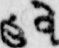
હવે
